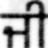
ਜੀ
